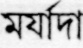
মর্যাদা
